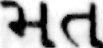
મત
